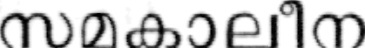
സമകാലീന
